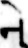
ને
